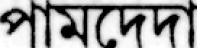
পামদেদা
